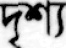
দৃশ্য
